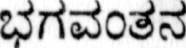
ಭಗವಂತನ
